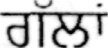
ਗੱਲਾਂ
